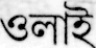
ওলাই
